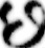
છ
